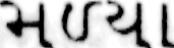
મળ્યા
